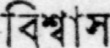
বিশ্বাস
